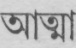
আত্মা
